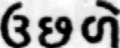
ઉછળે
